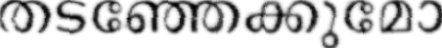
തടഞ്ഞേക്കുമോ
